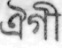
ঐগী
